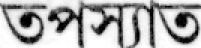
তপস্যাত
